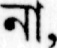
না,
